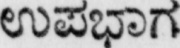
ಉಪಭಾಗ
